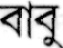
বাবু
